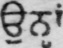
ਉਨ੍ਹਾਂ
